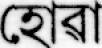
হোৱা
